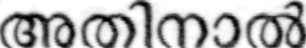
അതിനാല്‍
